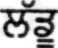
ਲੱਡੂ
